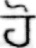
ਹੋ
